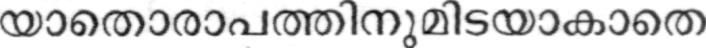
യാതൊരാപത്തിനുമിടയാകാതെ
